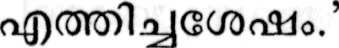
എത്തിച്ചശേഷം.’
